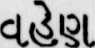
વહેણ
